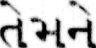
તેમને
